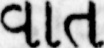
વાત
